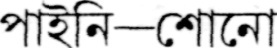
পাইনি–শোনো
